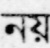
নয়
